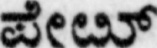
ಪೇೞು
